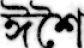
ঈশৈ
